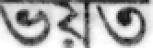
ভয়ত
